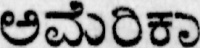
ಅಮೆರಿಕಾ
